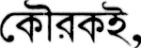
কৌরকই,
